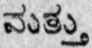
ಮತ್ತು
